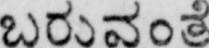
ಬರುವಂತೆ
